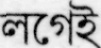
লগেই
